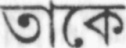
তাকে
